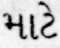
માટે
